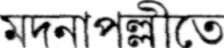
মদনাপল্লীতে
